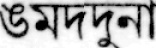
ঙমদদুনা
